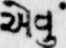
એવું
